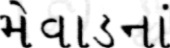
મેવાડનાં
